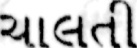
ચાલતી
